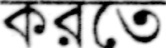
করতে
